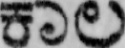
ಕಾಲ
